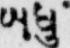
બધું
